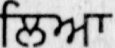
ਲਿਆ
